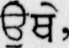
ਉਥੇ,
